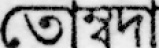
তোম্বদা
